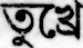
তুখ্রে
